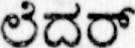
ಲೆದರ್
